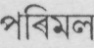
পৰিমল
